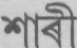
শাৰী
